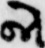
જો
